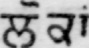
ਲੋਕਾਂ
